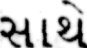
સાથે
